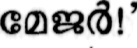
മേജര്‍!’
